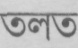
তলত
